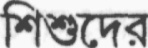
শিশুদের
